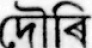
দৌৰি
